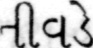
નીવડે
